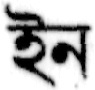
ইন
